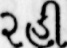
રહી
